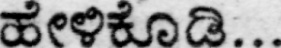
ಹೇಳಿಕೊಡಿ...
